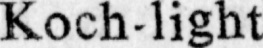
Koch-light
